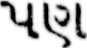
પણ
